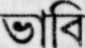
ভাবি
